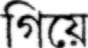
গিয়ে
